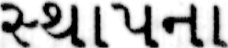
સ્થાપના
